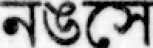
নঙসে
